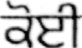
ਕੋਈ
